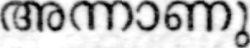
അന്നാണു
